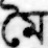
মৈ
